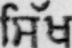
ਸਿੱਖ
